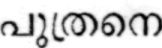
പുത്രനെ
